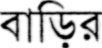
বাড়ির
